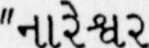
"નારેશ્વર
